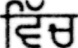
ਵਿੱਚ
